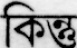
কিন্তু
